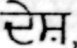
ਦੇਸ਼,
